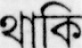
থাকি
